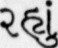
રહ્યું
